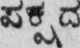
ಪಕ್ಷದ
